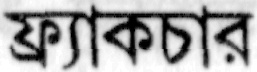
ফ্র্যাকচার
